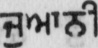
ਜੁਆਨੀ
